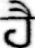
ਹੈ
